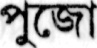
পুজো
